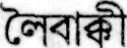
লৈবাক্কী
